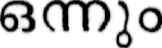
ഒന്നും
